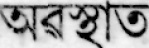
অৱস্থাত
